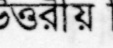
উত্তরীয়
